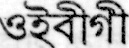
ওইবীগী
